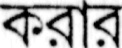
করার
